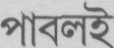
পাবলই
